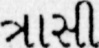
ત્રાસી
